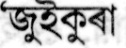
'জুইকুৰা
